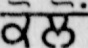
ਕੋਲੋਂ
